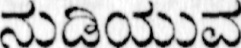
ನುಡಿಯುವ
